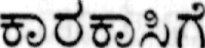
ಕಾರಕಾಸಿಗೆ
